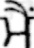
ਮੈਂ
